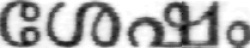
ശേഷം
